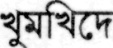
খুমখিদে
